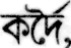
কর্দৈ,
